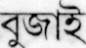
বুজাই
